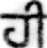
ਹੀ
